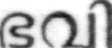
ഭവി
